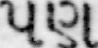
પણ
